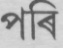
পৰি
